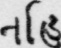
નહિ
